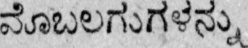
ಮೊಬಗುಗಳನ್ನು
